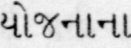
યોજનાના
